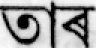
তাৰ
